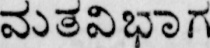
ಮತವಿಭಾಗ
